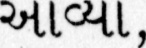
આવ્યા,
